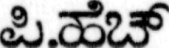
ಪಿ.ಹೆಚ್
